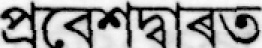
প্রবেশদ্বাৰত
